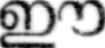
ഈ
